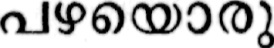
പഴയൊരു
